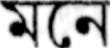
মনে
